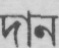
দান
